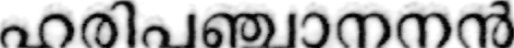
ഹരിപഞ്ചാനനന്‍
